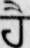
ਹੈ
